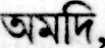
অমদি,
